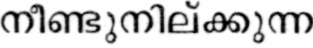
നീണ്ടുനില്ക്കുന്ന
